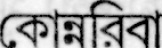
কোন্নরিবা
